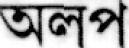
অলপ
